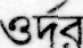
ওর্দর
